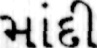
માંદી
